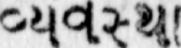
વ્યવસ્થા
